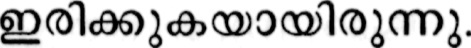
ഇരിക്കുകയായിരുന്നു.
